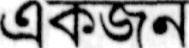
একজন
